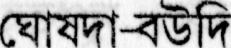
ঘোষদা-বউদি
